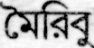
মৈরিবু
